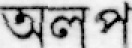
অলপ
